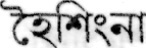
হৈশিংনা
